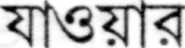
যাওয়ার
